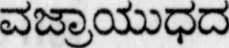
ವಜ್ರಾಯುಧದ
